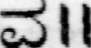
ವ||
